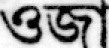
ওজা
